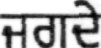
ਜਗਦੇ
